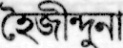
হৈজীন্দুনা
